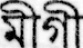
মীগী
